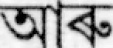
আৰু
